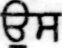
ਉਸ
